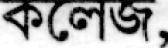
কলেজ,
